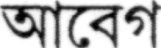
আবেগ
